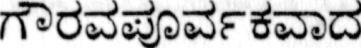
ಗೌರವಪೂರ್ವಕವಾದ
